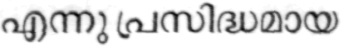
എന്നുപ്രസിദ്ധമായ
